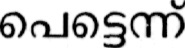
പെട്ടെന്ന്
